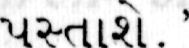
પસ્તાશે.'
